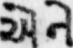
એને
